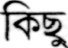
কিছু
